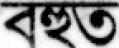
বহুত
